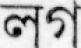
লগ
